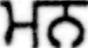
ਮਨ
